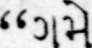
"ગમે
